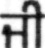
ਜੀ
